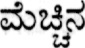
ಮೆಚ್ಚಿನ
